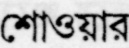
শোওয়ার
